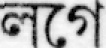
লগে
